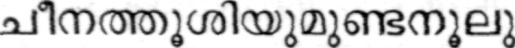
ചീനത്തൂശിയുമുണ്ടനൂലു
